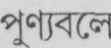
পুণ্যবলে
